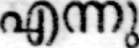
എന്നു
